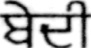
ਬੇਦੀ
